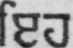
ਇਹ
